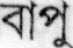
বাপু
